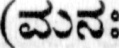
(ಮನಃ
